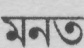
মনত
